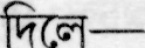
দিলে-
